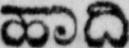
ಹಾದಿ
